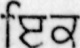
ਇਕ
